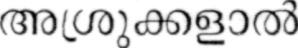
അശ്രുക്കളാല്‍
